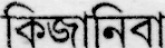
কিজানিবা
